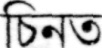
চিনত
